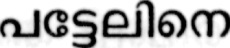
പട്ടേലിനെ
